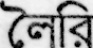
লৈরি
